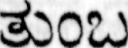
ತುಂಬ
